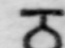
ਨ
